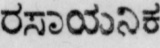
ರಸಾಯನಿಕ
